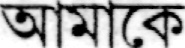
আমাকে
